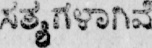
ಸತ್ಯಗಳಾಗಿವೆ
